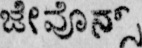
ಜೇವೊನ್ಸ್
